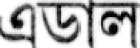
এডাল
